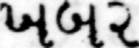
ખબર
